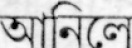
আনিলে
